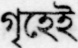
গৃহেই
